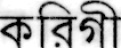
করিগী
